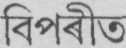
বিপৰীত
